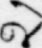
જે
